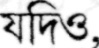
যদিও,
